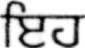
ਇਹ
